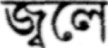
জ্বলে
